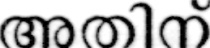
അതിന്
